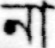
না
